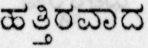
ಹತ್ತಿರವಾದ
